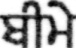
ਬੀਮੇ
